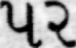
પર
